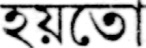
হয়তো
